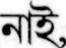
নাই,
